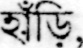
হাঁড়ি,
